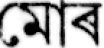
মোৰ
